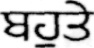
ਬਹੁਤੇ
